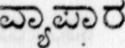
ವ್ಯಾಪಾರ
